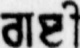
ਗਈ
